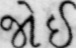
જોઈ
